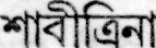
শাবীত্রিনা
